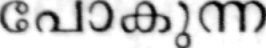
പോകുന്ന
